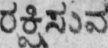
ರಕ್ಷಿಸುವ
